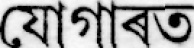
যোগাৰত
